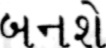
બનશે
